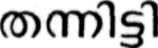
തന്നിട്ടി
